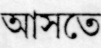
আসতে
